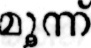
മൂന്ന്
